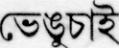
ভেঙুচাই
